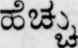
ಹೆಚ್ಚು
